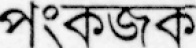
পংকজক
